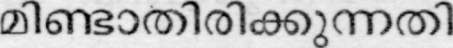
മിണ്ടാതിരിക്കുന്നതി
